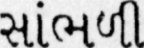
સાંભળી
